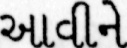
આવીને
